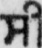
ਸੀ
